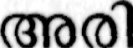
അരി
